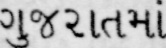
ગુજરાતમાં
